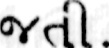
જતી.
